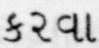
કરવા
